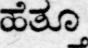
ಹೆತ್ತೂ
